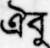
ঐবু
